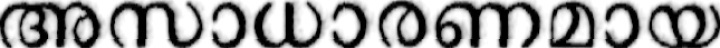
അസാധാരണമായ
